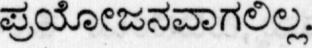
ಪ್ರಯೋಜನವಾಗಲಿಲ್ಲ.
